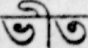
ভীত
